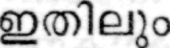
ഇതിലും
